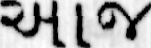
આજ
